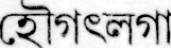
হৌগৎলগা
